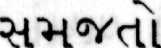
સમજતો
